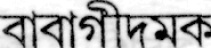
বাবাগীদমক
